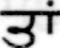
ਤਾਂ
